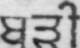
ਬੜੀ
